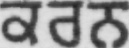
ਕਰਨ
